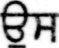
ਉਸ
